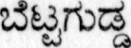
ಬೆಟ್ಟಗುಡ್ಡ
